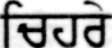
ਚਿਹਰੇ
